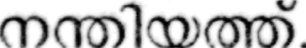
നന്തിയത്ത്.
